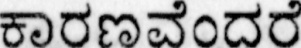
ಕಾರಣವೆಂದರೆ
